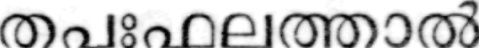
തപഃഫലത്താല്‍
